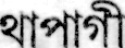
থাপাগী
